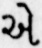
એ
